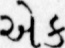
એક
